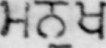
ਮਨੁਖ
